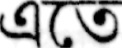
এতে
